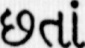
છતાં
